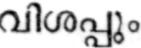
വിശപ്പും
